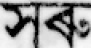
সৰু
